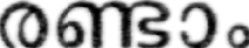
രണ്ടാം
